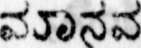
ಮಾನವ
